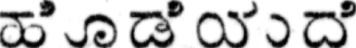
ಹೊಡೆಯದೆ
